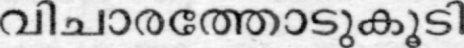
വിചാരത്തോടുകൂടി
